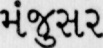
મંજુસર
